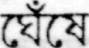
ঘেঁষে
